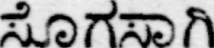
ಸೊಗಸಾಗಿ
